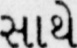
સાથે
